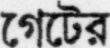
গেটের
